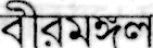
বীরমঙ্গল
